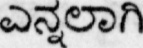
ಎನ್ನಲಾಗಿ
